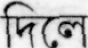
দিলে
